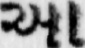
આ
